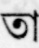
তা
